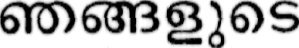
ഞങ്ങളുടെ
